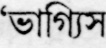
‘ভাগ্যিস
